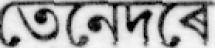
তেনেদৰে
